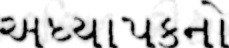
અધ્યાપકનો
